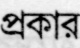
প্রকার
